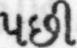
પછી
